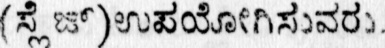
(ಸ್ಲೆಜ್)ಉಪಯೋಗಿಸುವರು.
